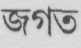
জগত
